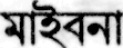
মাইবনা
